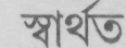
স্বাৰ্থত
